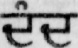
ਦੰਦ
